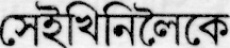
সেইখিনিলৈকে
